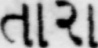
તારા
